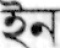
ইন
